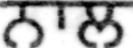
ਨਾਲ
